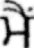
ਮੈਂ
